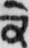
ਕੇ
